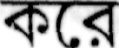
করে
